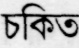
চকিত
